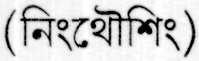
(নিংথৌশিং)
